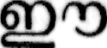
ഈ
